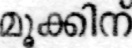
മൂക്കിന്
